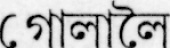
গোলালৈ
